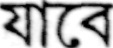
যাবে
